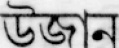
উজান
